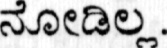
ನೋಡಿಲ್ಲ.
